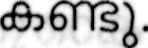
കണ്ടു.
